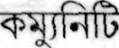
কম্যুনিটি
